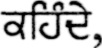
ਕਹਿੰਦੇ,
